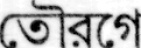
তৌরগে
